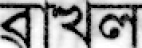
ৱাখল
